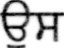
ਉਸ
